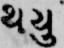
થયું
